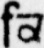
ਕਿ
